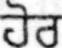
ਹੋਰ
